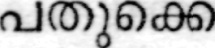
പതുക്കെ
